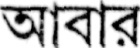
আবার
